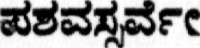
ಪಶವಸ್ಸರ್ವೇ
